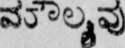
ಮೌಲ್ಯವು
